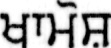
ਖਾਮੋਸ਼
